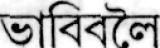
ভাবিবলৈ
